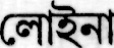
লোইনা
